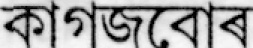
কাগজবোৰ
